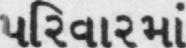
પરિવારમાં
